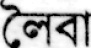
লৈবা
